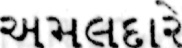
અમલદારે
